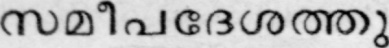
സമീപദേശത്തു
